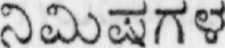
ನಿಮಿಷಗಳ
